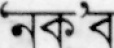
'নক'ব
